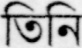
তিনি
